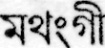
মথংগী
